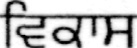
ਵਿਕਾਸ
